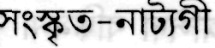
সংস্কৃত-নাট্যগী
